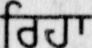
ਰਿਹਾ
